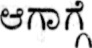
ಆಗಾಗ್ಗೆ
